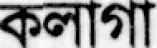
কলাগা
